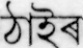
ঠাইৰ
